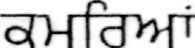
ਕਮਰਿਆਂ
